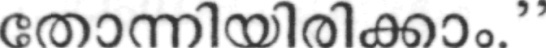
തോന്നിയിരിക്കാം."
